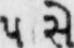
પાસે
